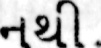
નથી.
